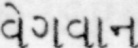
વેગવાન
